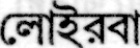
লোইরবা
